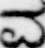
ವ
